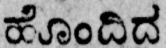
ಹೊಂದಿದ
